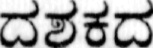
ದಶಕದ
